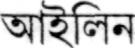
আইলিন
